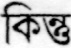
কিন্তু
